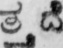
ತ್ತದೆ
